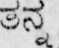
ತನ್ನ
